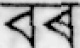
বৰ
